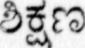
ಶಿಕ್ಷಣ
